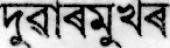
দুৱাৰমুখৰ
